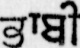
ਭਾਬੀ
